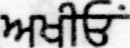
ਅਖੀਓਂ
